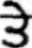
ਤੇ
